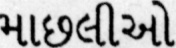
માછલીઓ
